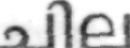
ചില
